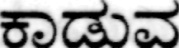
ಕಾಡುವ
